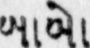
બાબો
